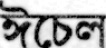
ঈচেল
